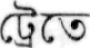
ট্রেতে
